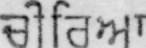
ਚੀਰਿਆ
